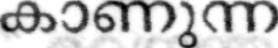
കാണുന്ന
